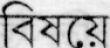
বিষয়ে
